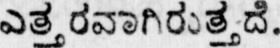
ಎತ್ತರವಾಗಿರುತ್ತದೆ.
